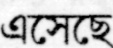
এসেছে
